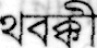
থবক্কী
